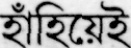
হাঁহিয়েই
